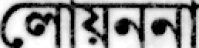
লোয়ননা
